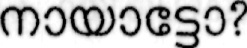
നായാട്ടോ?
